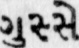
ગુસ્સે
